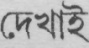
দেখাই
